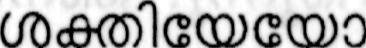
ശക്തിയേയോ
